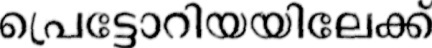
പ്രെട്ടോറിയയിലേക്ക്
